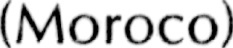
(Moroco)
